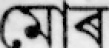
মোৰ
